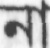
না
